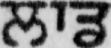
ਲਾਡ
